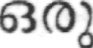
ഒരു
